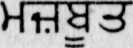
ਮਜ਼ਬੂਤ
